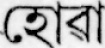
হোৱা
